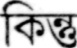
কিন্তু
